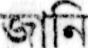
জানি
